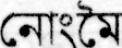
নোংমৈ
